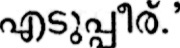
എടുപ്പീര്.’
